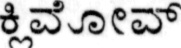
ಕ್ಲಿಮೋವ್
